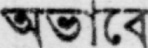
অভাবে
